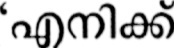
‘എനിക്ക്
